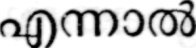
എന്നാല്‍
